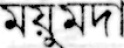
ময়ুমদা
